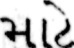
માટે
